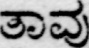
ತಾವು
